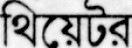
থিয়েটর
